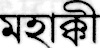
মহাক্কী
